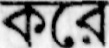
করে
